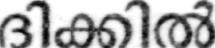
ദിക്കില്‍
